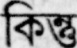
কিন্তু
